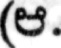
(ಆ.
